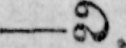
-ವಿ.
